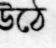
উঠে
